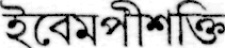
ইবেমপীশক্তি
